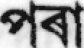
পৰা
